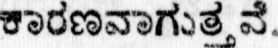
ಕಾರಣವಾಗುತ್ತವೆ.
